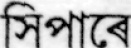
সিপাৰে
